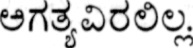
ಅಗತ್ಯವಿರಲಿಲ್ಲ.
